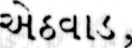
એઠવાડ,
